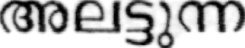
അലട്ടുന്ന
